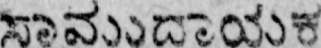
ಸಾಮುದಾಯಕ
